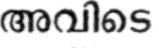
അവിടെ
